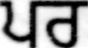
ਪਰ
